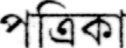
পত্রিকা
